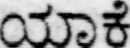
ಯಾಕೆ
